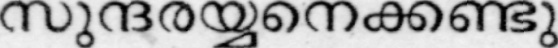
സുന്ദരയ്യനെക്കണ്ടു
